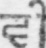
ਵੀ
